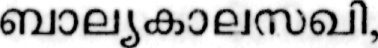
ബാല്യകാലസഖി,
